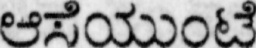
ಆಸೆಯುಂಟೆ
